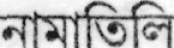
নামাতিলি
